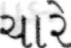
ચારે
